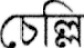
চেল্লি
